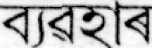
ব্যৱহাৰ
